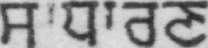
ਸਾਧਾਰਣ
